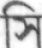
সি
